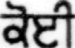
ਕੋਈ
